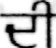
ਦੀ
